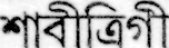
শাবীত্রিগী
